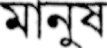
মানুষ
